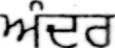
ਅੰਦਰ
